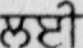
ਲਈ
